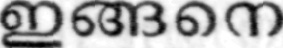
ഇങ്ങനെ
